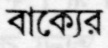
বাক্যের
